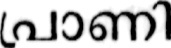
പ്രാണി
